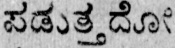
ಪಡುತ್ತಧೋ
